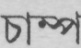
চাম্প
